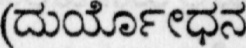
(ದುರ್ಯೋಧನ
